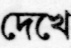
দেখে
